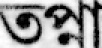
তপ্না
